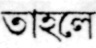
তাহলে
